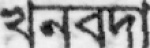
খনবদা
